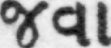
જવા
